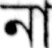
না
